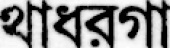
থাধরগা
